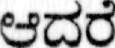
ಆದರೆ
